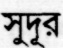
সুদূর
